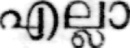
എല്ലാ
